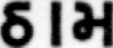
ઠામ
